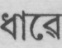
ধাৱে
